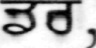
ਡਰ,
